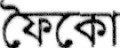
ফৈকো
